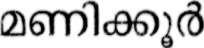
മണിക്കൂര്‍
